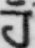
ਹੋ
